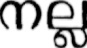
നല്ല
